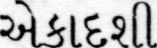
એકાદશી
